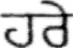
ਹਰੇ
